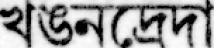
খঙনদ্রেদা
